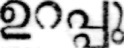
ഉറപ്പു
